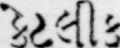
કેટલીક
